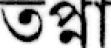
তপ্না
